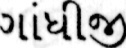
ગાંધીજી
